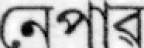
নেপাৱ
